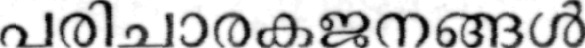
പരിചാരകജനങ്ങള്‍
